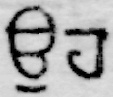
ਉਹ
